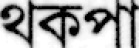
থকপা
